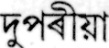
দুপৰীয়া
